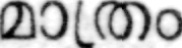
മാത്രം
